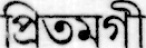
প্রিতমগী
